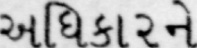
અધિકારને
